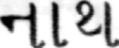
નાથ
